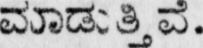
ಮಾಡುತ್ತಿವೆ.
